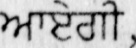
ਆਏਗੀ,
